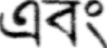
এবং
